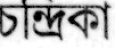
চন্দ্রিকা
